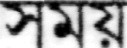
সময়
